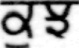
ਕੁਝ
